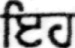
ਇਹ
